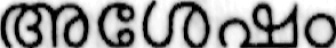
അശേഷം
